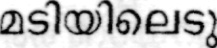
മടിയിലെടു
